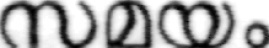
സമയം
